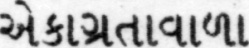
એકાગ્રતાવાળા
